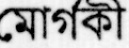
মো্র্গকী
